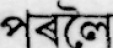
পৰলৈ
